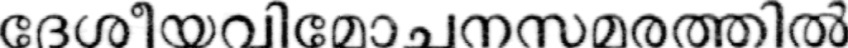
ദേശീയവിമോചനസമരത്തില്‍
